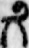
ಗೆ
